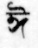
ঈ
